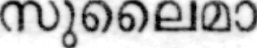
സുലൈമാ
